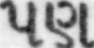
પણ
